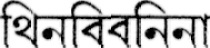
থিনবিবনিনা
